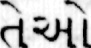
તેઓ
